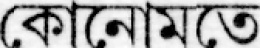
কোনোমতে
